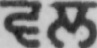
ਵਲ
